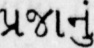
પ્રજાનું
